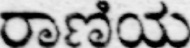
ರಾಣಿಯ
